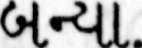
બન્યા.
